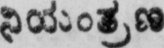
ನಿಯಂತ್ರಣ
